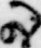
જે
